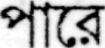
পারে
